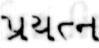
પ્રયત્ન
